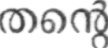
തന്റെ
